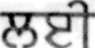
ਲਈ
